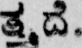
ತ್ತದೆ.
